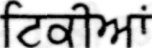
ਟਿਕੀਆਂ
